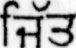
ਜਿੱਤ
